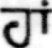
ਹਾਂ
